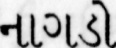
નાગડો
